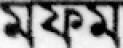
মফম
